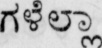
ಗಳೆಲ್ಲಾ
